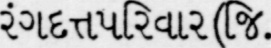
રંગદત્તપરિવાર
